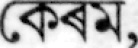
কেৰম,
